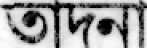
তাদনা
